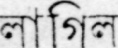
লাগিল
